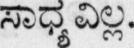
ಸಾಧ್ಯವಿಲ್ಲ.
